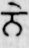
ਨੇ
